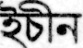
ইচীন
